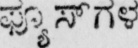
ಫ್ಯೂಸ್‌ಗಳ
